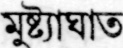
মুষ্ট্যাঘাত
